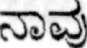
ನಾವು
